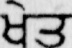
ਖੇਤ
